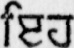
ਇਹ
